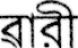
ৱারী
